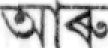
আৰু
